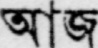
আজ
